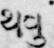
થવું
